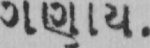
ગણાય.
